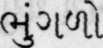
ભુંગળો
